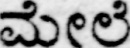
ಮೇಲೆ
